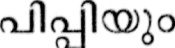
പിപ്പിയും
